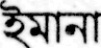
ইমানা
